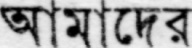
আমাদের
